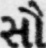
સૌ
